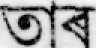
তাৰ
